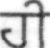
ਹੀ
